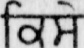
ਕਿਸੇ
